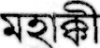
মহাক্কী
